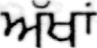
ਅੱਖਾਂ
